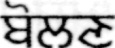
ਬੋਲਣ
